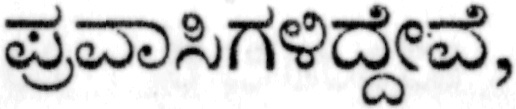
ಪ್ರವಾಸಿಗಳಿದ್ದೇವೆ,
